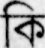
কি
